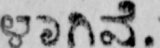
ಳಾಗಿವೆ.
